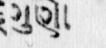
સદ્ગુણો
